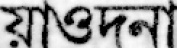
য়াওদনা
